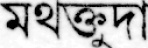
মথক্তুদা
